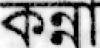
কন্না
